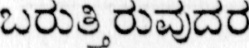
ಬರುತ್ತಿರುವುದರ
